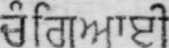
ਚੰਗਿਆਈ
